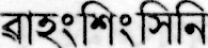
ৱাহংশিংসিনি
